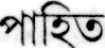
পাহিত
